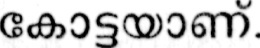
കോട്ടയാണ്.
